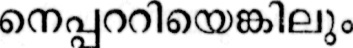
നെപ്പററിയെങ്കിലും
